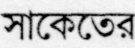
সাকেতের
